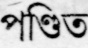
পণ্ডিত
